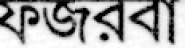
ফজরবা
